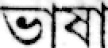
ভাষা
